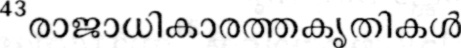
43രാജാധികാരത്തകൃതികള്‍
